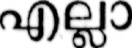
എല്ലാ
